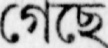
গেছে
